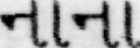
નાના
